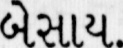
બેસાય.
